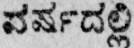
ವರ್ಷದಲ್ಲಿ
